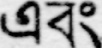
এবং
